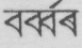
বৰ্ব্বৰ
